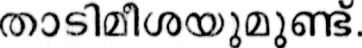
താടിമീശയുമുണ്ട്.
